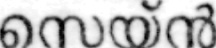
സെയ്ന്‍
